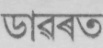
ডাৱৰত
